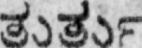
ತುರ್ತು
